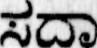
ಸದಾ
